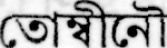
তোম্বীনৌ
